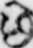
છે
